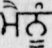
ਮੈਨੂੰ
